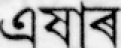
এষাৰ
